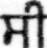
ਸੀ
